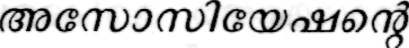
അസോസിയേഷന്റെ
